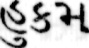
હુકમ
